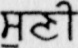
ਸੁਣੀ
